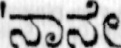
‘ನಾನೇ
